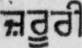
ਜ਼ਰੂਰੀ
